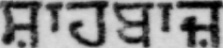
ਸ਼ਾਹਬਾਜ਼
